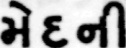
મેદની
